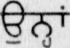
ਉਨ੍ਹਾਂ
